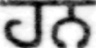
ਹਨ
